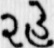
રહે
